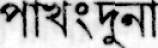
পাখংদুনা
